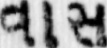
વાસ
